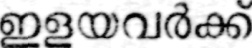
ഇളയവര്‍ക്ക്
